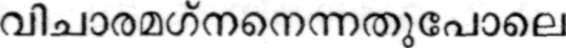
വിചാരമഗ്നനെന്നതുപോലെ
